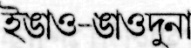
ইঙাও-ঙাওদুনা
